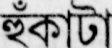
হুঁকাটা
